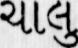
ચાલુ
